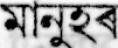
মানুহৰ
